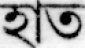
হাত
